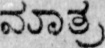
ಮಾತ್ರ
